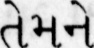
તેમને
